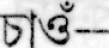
চাওঁ-
